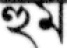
হুম
